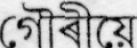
গৌৰীয়ে
